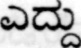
ಎದ್ದು
